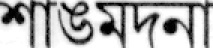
শাঙমদনা
